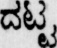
ದಟ್ಟ
